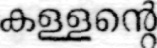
കള്ളന്റെ
